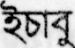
ইচাবু
